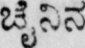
ಚೈನಿನ
